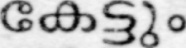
കേട്ടും
